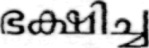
ഭക്ഷിച്ച
